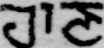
ਹਾਣ
